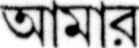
আমার
